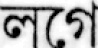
লগে
